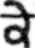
ਕੇ
